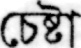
চেষ্টা
